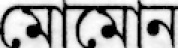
মোমোন
